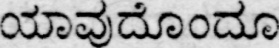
ಯಾವುದೊಂದೂ
